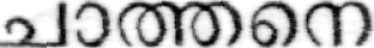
ചാത്തനെ
